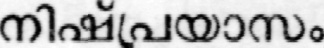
നിഷ്പ്രയാസം
